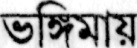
ভঙ্গিমায়
